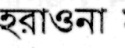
হরাওনা
